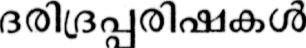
ദരിദ്രപ്പരിഷകള്‍
